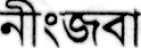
নীংজবা
